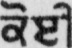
ਕੋਈ
